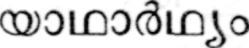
യാഥാര്‍ഥ്യം
